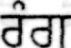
ਰੰਗ
